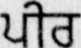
ਪੀਰ
